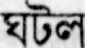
ঘটল
